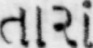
તારાં
